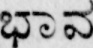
ಭಾವ
